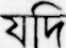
যদি
